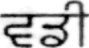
ਵਡੀ
